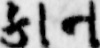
કાન
